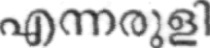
എന്നരുളി
